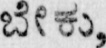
ಬೇಕು,
